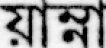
য়াম্না
